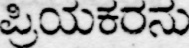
ಪ್ರಿಯಕರನು
